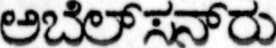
ಅಬೆಲ್‌ಸನ್‌ರು
